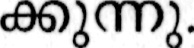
ക്കുന്നു.
